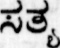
ಸತ್ಯ
